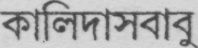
কালিদাসবাবু
